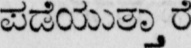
ಪಡೆಯುತ್ತಾರೆ
